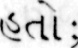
હતો;
